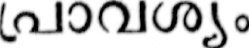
പ്രാവശ്യം
